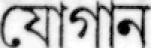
যোগান
